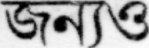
জন্যও
